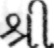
શ્રી
